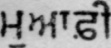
ਮੁਆਫ਼ੀ
